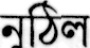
নুঠিল
